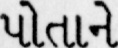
પોતાને
